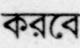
করবে
